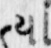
ત્યાં
